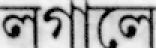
লগালে
